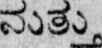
ಮತ್ತು
